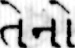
તેનો
